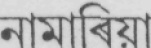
নামাৰিয়া
